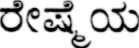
ರೇಷ್ಮೆಯ
